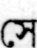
সে
